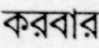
করবার
